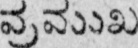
ವ್ರಮುಖ
